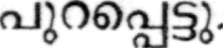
പുറപ്പെട്ടു.
